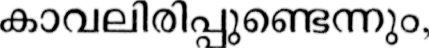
കാവലിരിപ്പുണ്ടെന്നും,
